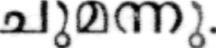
ചുമന്നു.
